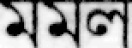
মমল
